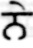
ਨੇ
